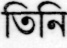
তিনি
